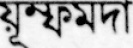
য়ূম্ফমদা
